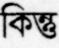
কিন্তু
